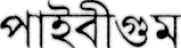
পাইবীগুম
